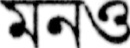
মনও
